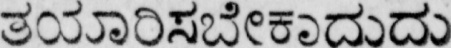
ತಯಾರಿಸಬೇಕಾದುದು
